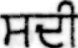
ਸਦੀ
